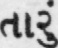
તારું
